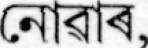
নোৱাৰ,
